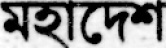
মহাদেশ
